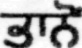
ਭਾਨੋਂ
